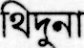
থিদুনা
